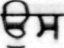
ਉਸ
